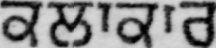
ਕਲਾਕਾਰ
